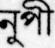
নুপী
